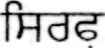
ਸਿਰਫ਼
